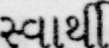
સ્વાર્થી
